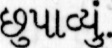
છુપાવ્યું.
